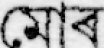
মোৰ
